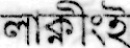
লাক্নীংই
